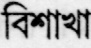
বিশাখা
